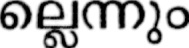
ല്ലെന്നും
